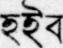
হইব
